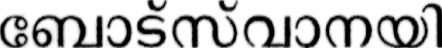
ബോട്സ്വാനയി
